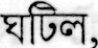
ঘটিল,
